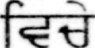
ਵਿਚੇ
